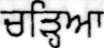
ਚੜ੍ਹਿਆ
